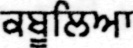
ਕਬੂਲਿਆ
